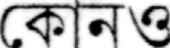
কোনও
